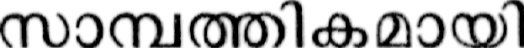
സാമ്പത്തികമായി
